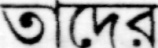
তাদের
